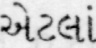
એટલાં
